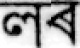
লৰ
